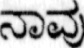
ನಾವು
